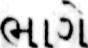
ભાગે
